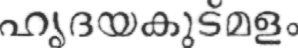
ഹൃദയകുട്മളം
